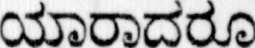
ಯಾರಾದರೂ
